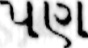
પણ
